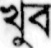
খুব
